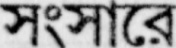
সংসারে
